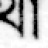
থা
